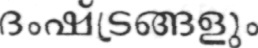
ദംഷ്ട്രങ്ങളും
